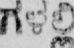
ಗಳಲ್ಲಿ
